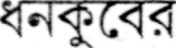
ধনকুবের
